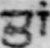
ਤਾਂ
